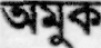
অমুক
